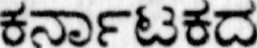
ಕರ್ನಾಟಕದ
